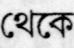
থেকে
